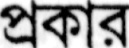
প্রকার
